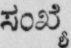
ಸಂಖ್ಯೆ
